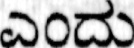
ಎಂದು
